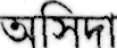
অসিদা
